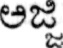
ಅಜ್ಜಿ
